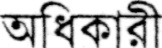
অধিকারী
